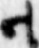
ન
